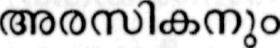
അരസികനും
